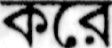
করে
